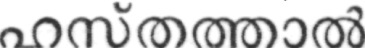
ഹസ്തത്താല്‍
